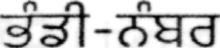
ਭੰਡੀ-ਨੰਬਰ
